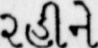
રહીને
